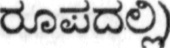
ರೂಪದಲ್ಲಿ)
